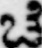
ಚೆ
